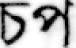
চপ
